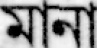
মানা
